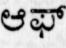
ಆಫ್
